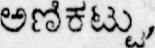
ಅಣೆಕಟ್ಟು,
